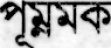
পূম্নমক
